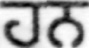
ਹਨ
